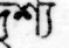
দৃশ্য
